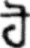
ਹੋ
